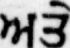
ਅਤੇ
